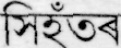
সিহঁতৰ
